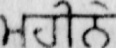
ਮਹੀਨੇ
